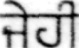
ਜੇਹੀ
